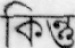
কিন্তু
